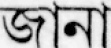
জানা
